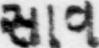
સાવ
